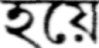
হয়ে
